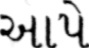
આપે
